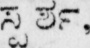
ಸ್ಪರ್ಶ,
